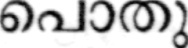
പൊതു
